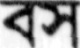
বস
